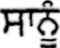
ਸਾਨੂੰ
